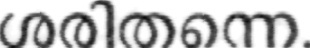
ശരിതന്നെ.
